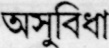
অসুবিধা
